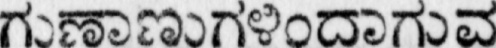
ಗುಣಾಣುಗಳಿಂದಾಗುವ
